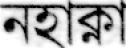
নহাক্না
